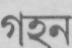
গহন
